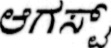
ಆಗಸ್ಟ್
